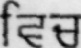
ਵਿਚ
